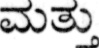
ಮತ್ತು
